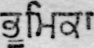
ਭੂਮਿਕਾ
